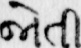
જોતી
